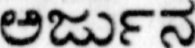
ಅರ್ಜುನ
